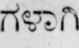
ಗಳಾಗಿ
